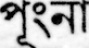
পূংনা
